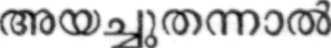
അയച്ചുതന്നാല്‍
